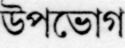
উপভোগ
